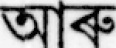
আৰু
